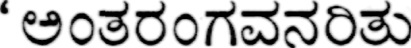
'ಅಂತರಂಗವನರಿತು
